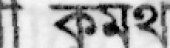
ফংলবা
